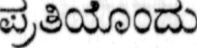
ಪ್ರತಿಯೊಂದು
